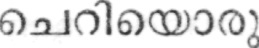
ചെറിയൊരു
